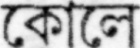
কোলে
